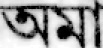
অমা
